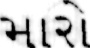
મારો
